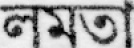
লমতা
